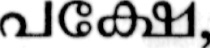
പക്ഷേ,
